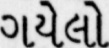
ગયેલો
